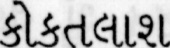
કોકતલાશ
